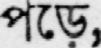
পড়ে,
